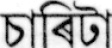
চাৰিটা
